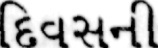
દિવસની
